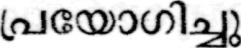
പ്രയോഗിച്ചു
